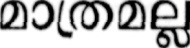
മാത്രമല്ല
